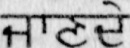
ਜਾਣਦੇ
